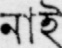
নাই
